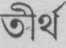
তীৰ্থ
